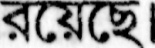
রয়েছে।
